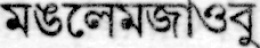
মঙলেমজাওবু
